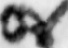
જ
